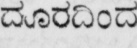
ದೂರದಿಂದ
